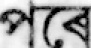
পৰে
